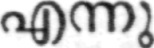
എന്നു
